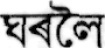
ঘৰলৈ
